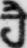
ਹੈ
